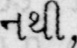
નથી,
